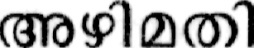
അഴിമതി
